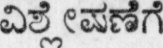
ವಿಶ್ಲೇಷಣೆಗೆ
